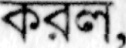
করল,
